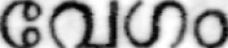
വേഗം
